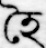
হৈ
